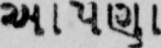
આપણા
